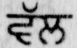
ਵੱਲ
